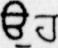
ਉਹ
